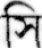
সি
